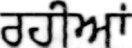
ਰਹੀਆਂ
